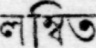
লম্বিত
